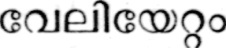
വേലിയേറ്റം
